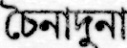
চৈনাদুনা
